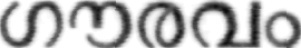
ഗൌരവം
